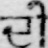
ਦੀ
